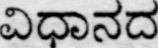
ವಿಧಾನದ
